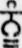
ਨੂੰ
